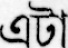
এটা
